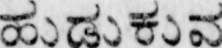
ಹುಡುಕುವ
